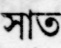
সাত
